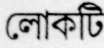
লোকটি
